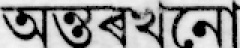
অন্তৰখনো
